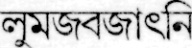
লুমজবজাৎনি
